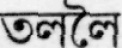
তললৈ
